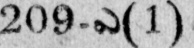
209-ಎ(1)
